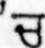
'ਚ
